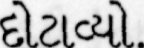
દોટાવ્યો.
